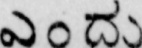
ಎಂದು
